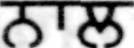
ਨਾਲ
